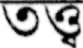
তত্ত্ব
